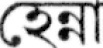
হেন্না
